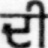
ਦੀ
